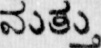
ಮತ್ತು
